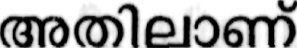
അതിലാണ്
